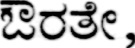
ಔರತೇ,
